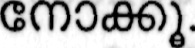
നോക്കൂ.
